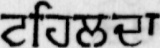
ਟਹਿਲਦਾ
